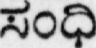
ಸಂಧಿ
